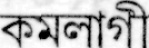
কমলাগী
